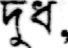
দুধ,
